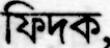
ফিদক,
